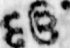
દઉં
